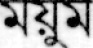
ময়ুম
